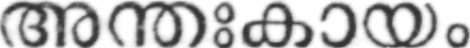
അന്തഃകായം
